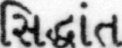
સિદ્ધાંત
